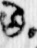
છે.
